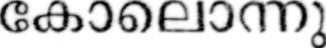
കോലൊന്നു
